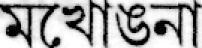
মখোঙনা
